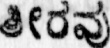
ತೀರವು
